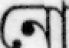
নো
